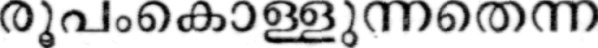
രൂപംകൊള്ളുന്നതെന്ന
